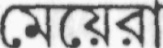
মেয়েরা
